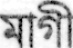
মাগী
